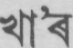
খা'ৰ
